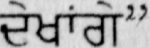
ਦੇਖਾਂਗੇ''
